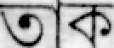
তাক
